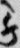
કે
